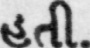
હતી.
